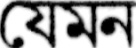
যেমন
